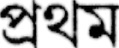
প্রথম
